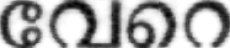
വേറെ
